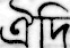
ঐদি
